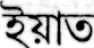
ইয়াত
